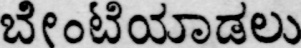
ಬೇಂಟೆಯಾಡಲು
